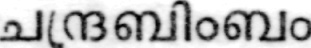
ചന്ദ്രബിംബം
